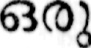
ഒരു
